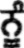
ਨੂੰ
